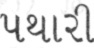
પથારી
